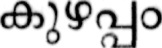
കുഴപ്പം
